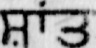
ਸ਼ਾਂਤ
